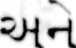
અને
